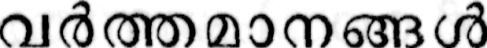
വര്‍ത്തമാനങ്ങള്‍
